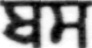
ਬਸ
